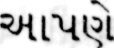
આપણે
